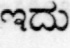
ಇದು
